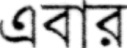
এবার
